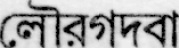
লৌরগদবা
